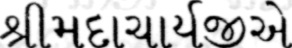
શ્રીમદાચાર્યજીએ
